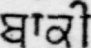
ਬਾਕੀ
